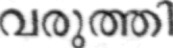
വരുത്തി
